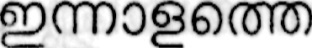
ഇന്നാളത്തെ
